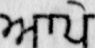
ਆਪੇ
